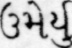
ઉમેર્યુ
